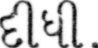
દીધી.
